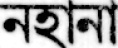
নহানা
